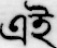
এই
